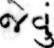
જેવું
